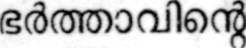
ഭര്‍ത്താവിന്റെ
